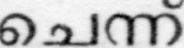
ചെന്ന്
